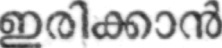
ഇരിക്കാന്‍
